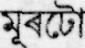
মূৰটো
